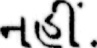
નહીં.
